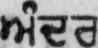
ਅੰਦਰ
